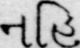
નહિ
